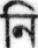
নি
